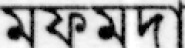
মফমদা
